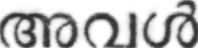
അവള്‍
